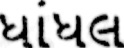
ધાંધલ
